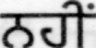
ਨਹੀਂ
